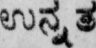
ಉನ್ನತ
